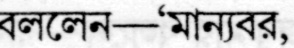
বললেন–‘মান্যবর,
